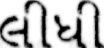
લીધી
